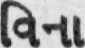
વિના
